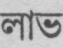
লাভ
